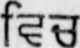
ਵਿਚ
